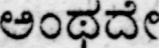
ಅಂಥದೇ
